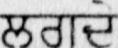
ਲਗਦੇ
